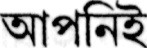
আপনিই
